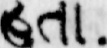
હતા.
